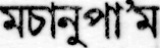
মচানুপা’ম
